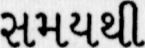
સમયથી
